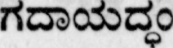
ಗದಾಯದ್ಧಂ
